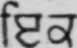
ਇਕ
